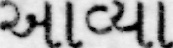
આવ્યા
